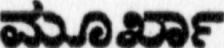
ಮೂರ್ಖಾ
